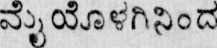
ಮೈಯೊಳಗಿನಿಂದ
